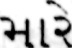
મારે
